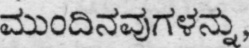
ಮುಂದಿನವುಗಳನ್ನು,
